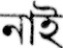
নাই
